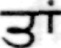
ਤਾਂ
